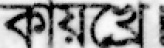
কায়খ্রে।
